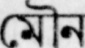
মৌন
